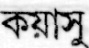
কয়াসু
